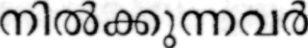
നില്‍ക്കുന്നവര്‍
